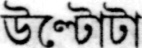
উল্টোটা
